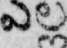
ಎಲ್ಲ
